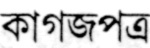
কাগজপত্র
